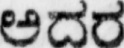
ಅದರ
